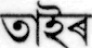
তাইৰ
